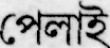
পেলাই
